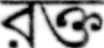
রক্ত
